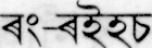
ৰং-ৰইহচ
